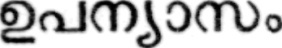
ഉപന്യാസം
